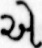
એ
